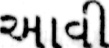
આવી
